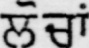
ਲੋਚਾਂ
